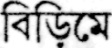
বিড়িমে
